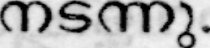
നടന്നു.
